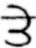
ਤੇ
